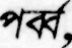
পর্ব্বা,
